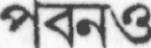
পবনও
